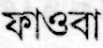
ফাওবা
